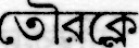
তৌরক্লে
